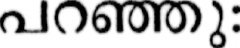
പറഞ്ഞു:
